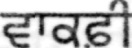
ਵਾਕਫ਼ੀ
